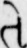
તે
